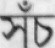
সঁচ
